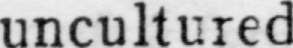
unclutured
